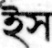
ইস
